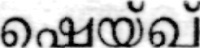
ഷെയ്ഖ്
